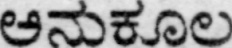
ಅನುಕೂಲ
